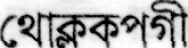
থোক্লকপগী
